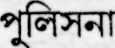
পুলিসনা
